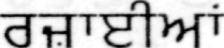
ਰਜ਼ਾਈਆਂ
